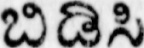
ಬಿಡಿಸಿ
